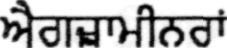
ਐਗਜ਼ਾਮੀਨਰਾਂ
